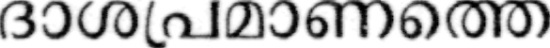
ദാശപ്രമാണത്തെ
